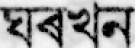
ঘৰখন
